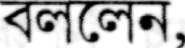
বললেন,
